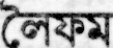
লৈফম
